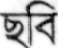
ছবি
